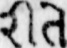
રીતે
